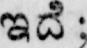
ಇದೆ;
